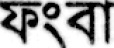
ফংবা
